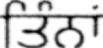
ਤਿੰਨਾਂ
